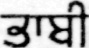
ਭਾਬੀ
